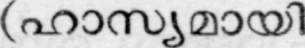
(ഹാസ്യമായി
